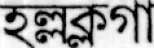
হল্লক্লগা
